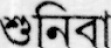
শুনিবা
